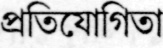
প্রতিযোগিতা
